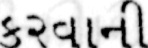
કરવાની
